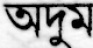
অদুম
